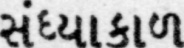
સંધ્યાકાળ
